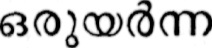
ഒരുയര്‍ന്ന
